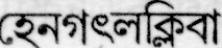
হেনগৎলক্লিবা
